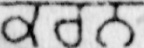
ਕਰਨ
